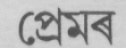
প্ৰেমৰ
